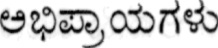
ಅಭಿಪ್ರಾಯಗಳು
